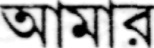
আমার
